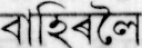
বাহিৰলৈ
